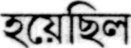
হয়েছিল
